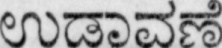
ಉಡಾವಣೆ
